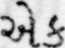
એક
